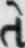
તે
